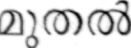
മുതല്‍
